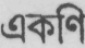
একণি
